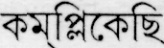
কম্‌প্লিকেছি
